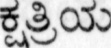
ಕ್ಷತ್ರಿಯ
